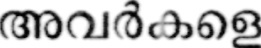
അവര്‍കളെ
